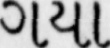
ગયા
